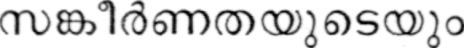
സങ്കീര്‍ണതയുടെയും
